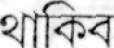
থাকিব
